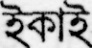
ইকাই
